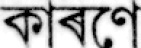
কাৰণে
